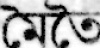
মৈতৈ
